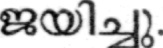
ജയിച്ചു.
